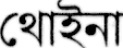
থোইনা
